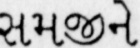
સમજીને
